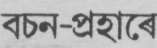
বচন-প্ৰহাৰে
